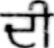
ਦੀ
